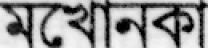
মখোনকা
